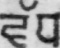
ਵੱਧ
